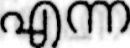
എന്ന
